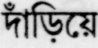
দাঁড়িয়ে
